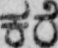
ಕರೆ
